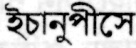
ইচানুপীসে
